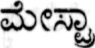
ಮೇಸ್ಟ್ರಾ
